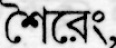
শৈরেং,
